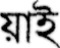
য়াই
